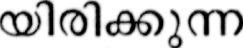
യിരിക്കുന്ന
